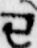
ਦੇ
